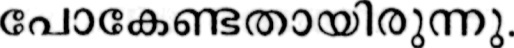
പോകേണ്ടതായിരുന്നു.
